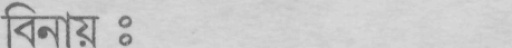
বিনায়ঃ
